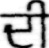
ਦੀ
